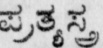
ಪ್ರತ್ಯಸ್ತ್ರ
